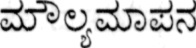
ಮೌಲ್ಯಮಾಪನ
